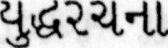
યુદ્ધરચના
